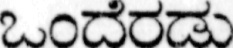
ಒಂದೆರಡು
